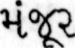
મંજૂર
